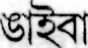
ঙাইবা
